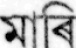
মাৰি
